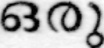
ഒരു
